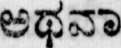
ಅಥವಾ
